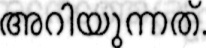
അറിയുന്നത്.
